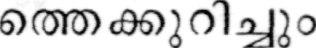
ത്തെക്കുറിച്ചും
